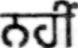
ਨਹੀਂ
